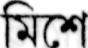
মিশে
